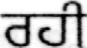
ਰਹੀ
